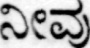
ನೀವು
